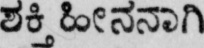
ಶಕ್ತಿಹೀನನಾಗಿ
